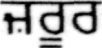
ਜ਼ਰੂਰ
